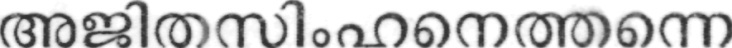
അജിതസിംഹനെത്തന്നെ
